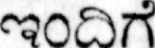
ಇಂದಿಗೆ
